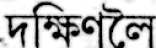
দক্ষিণলৈ
